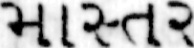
માસ્તર
